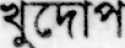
খুদোপ
